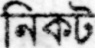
নিকট
